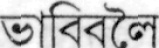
ভাবিবলৈ
